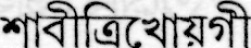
শাবীত্রিখোয়গী
